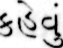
કહેવું
